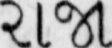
રાજા
